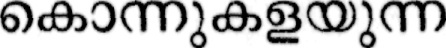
കൊന്നുകളയുന്ന
